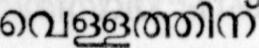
വെള്ളത്തിന്
